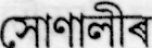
সোণালীৰ
